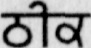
ਠੀਕ
